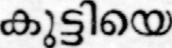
കുട്ടിയെ
